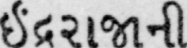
ઇંદ્રરાજાની
